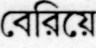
বেরিয়ে
